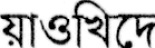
য়াওখিদে
